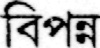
বিপন্ন
